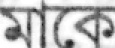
মাকে
